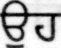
ਉਹ
